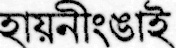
হায়নীংঙাই
